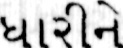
ધારીને
